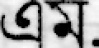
এম.
